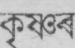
কৃষ্ণৰ
